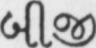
બીજી
